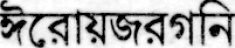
ঈরোয়জরগনি
